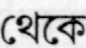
থেকে
